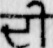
ਦੀ
